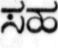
ಸಹ
